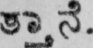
ತ್ತಾನೆ.
